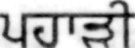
ਪਹਾੜੀ
